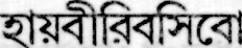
হায়বীরিবসিবো
